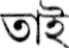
তাই
